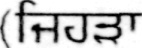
(ਜਿਹੜਾ
